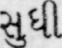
સુધી
